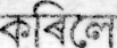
কৰিলে
